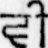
ਵੀ
